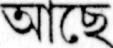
আছে
